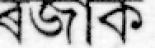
ৰজাক
